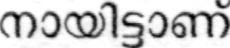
നായിട്ടാണ്
